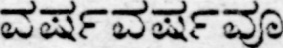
ವರ್ಷವರ್ಷವೂ
